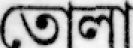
তোলা
